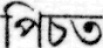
পিচত
